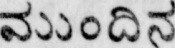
ಮುಂದಿನ
